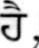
ਹੈ,
